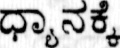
ಧ್ಯಾನಕ್ಕೆ
